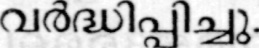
വര്‍ദ്ധിപ്പിച്ചു.
